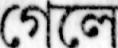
গেলে
